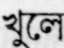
খুলে
